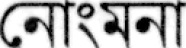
নোংমনা
